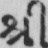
શ્રી
